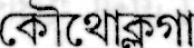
কৌথোক্লগা
